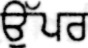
ਉੱਪਰ
